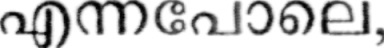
എന്നപോലെ,
